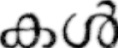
കള്‍
